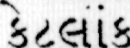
કેટલાંક
